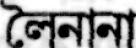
লৈনানা
